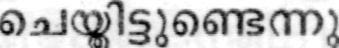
ചെയ്തിട്ടുണ്ടെന്നു
